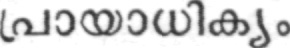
പ്രായാധിക്യം
